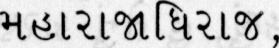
મહારાજાધિરાજ,
